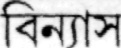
বিন্যাস
